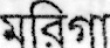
মরিগা
